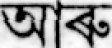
আৰু
